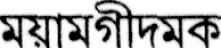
মায়ামগীদমক
